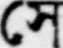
সে
